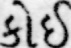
કોઈ
